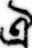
ঐ
